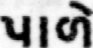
પાળે
